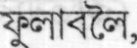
ফুলাবলৈ,
